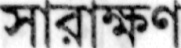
সারাক্ষণ
